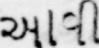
આવી
